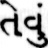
તેવું
